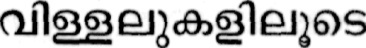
വിള്ളലുകളിലൂടെ
